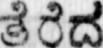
ತೆರೆದ
